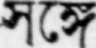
সঙ্গে
